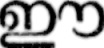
ഈ
